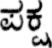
ಪಕ್ಷ
